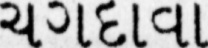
ચગદાવા
